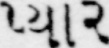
પ્યાર
